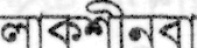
লাকশীনবা
